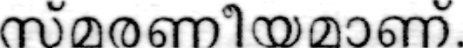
സ്മരണീയമാണ്.
